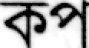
কপ
